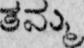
ತಮ್ಮ
